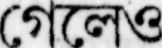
গেলেও
